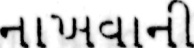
નાખવાની
